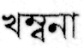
খম্বনা
